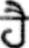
ਹੈ
